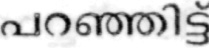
പറഞ്ഞിട്ട്
